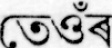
তেওঁৰ
